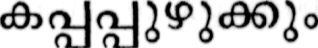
കപ്പപ്പുഴുക്കും
